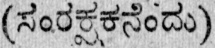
(ಸಂರಕ್ಷಕನೆಂದು)
